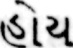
હોય
